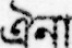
ঐনা
